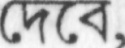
দেবে,
